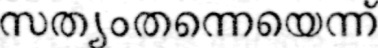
സത്യംതന്നെയെന്ന്
